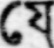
যে
